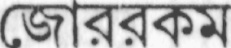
জোররকম
